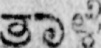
ತಾಳೆ
